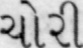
ચોરી
